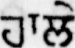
ਹਾਲੇ
